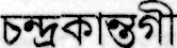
চন্দ্রকান্তগী
